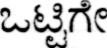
ಒಟ್ಟಿಗೇ
